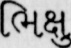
ભિક્ષુ
